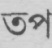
তপ
